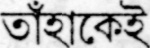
তাঁহাকেই
